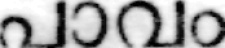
പാവം
